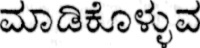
ಮಾಡಿಕೊಳ್ಳುವ
